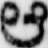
ಆ
